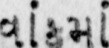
વાંકમાં
